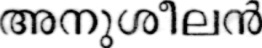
അനുശീലന്‍
